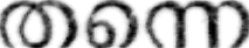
തന്നെ
